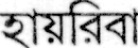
হায়রিবা
